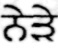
ਨੇੜੇ
